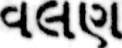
વલણ
